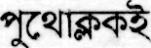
পুথোক্লকই
